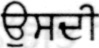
ਉਸਦੀ
